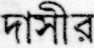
দাসীর
